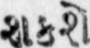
શકશે
